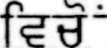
ਵਿਚੋਂ
